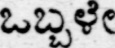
ಒಬ್ಬಳೇ
